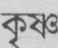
কৃষ্ণ
